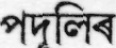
পদূলিৰ
